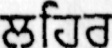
ਲਹਿਰ
